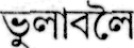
ভুলাবলৈ
